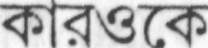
কারওকে
